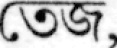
তেজ,
